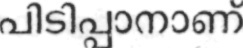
പിടിപ്പാനാണ്
